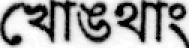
খোঙথাং
